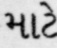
માટે
